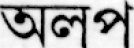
অলপ
